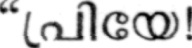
"പ്രിയേ!
